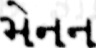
મેનન
